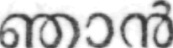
ഞാന്‍
